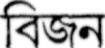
বিজন
